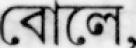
বোলে,
